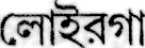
লোইরগা
